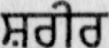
ਸ਼ਰੀਰ
